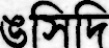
ঙসিদি
